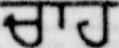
ਚਾਹ
